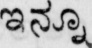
ಇನ್ನೂ
